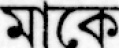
মাকে
